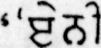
''ਏਨੀ
